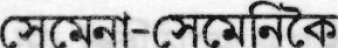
সেমেনা-সেমেনিকৈ
